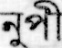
নুপী
